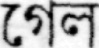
গেল
